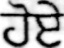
ਹੋਏ
